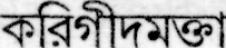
করিগীদমক্তা
